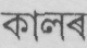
কালৰ
